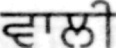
ਵਾਲੀ
